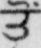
ਤੋਂ
